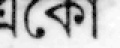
একো
